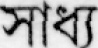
সাধ্য
